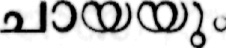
ചായയും
